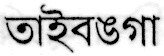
তাইবঙগা
